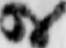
જ
